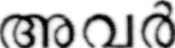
അവര്‍
